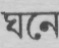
ঘনে
